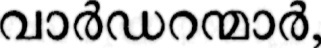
വാര്‍ഡറന്മാര്‍,
